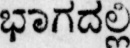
ಭಾಗದಲ್ಲಿ
